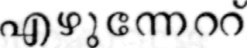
എഴുന്നേററ്
